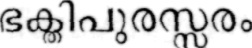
ഭക്തിപുരസ്സരം
